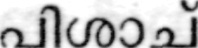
പിശാച്
